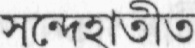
সন্দেহাতীত
